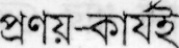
প্ৰণয়-কাৰ্যই
